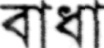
বাধা
